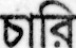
চারি
